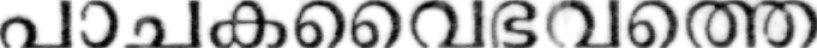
പാചകവൈഭവത്തെ
